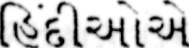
હિંદીઓએ
